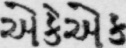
એકેએક
